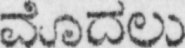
ಮೊದಲು
